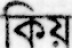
কিয়
